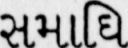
સમાધિ
